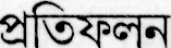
প্রতিফলন
